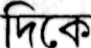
দিকে
